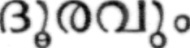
ദൂരവും
